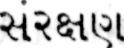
સંરક્ષણ
